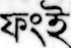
ফংই
